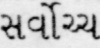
સર્વોચ્ચ
